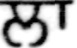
ਲਾ
